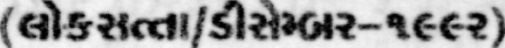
(લોકસત્તા/ડીસેમ્બર-૧૯૯૨)
